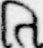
તિ
